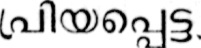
പ്രിയപ്പെട്ട.
